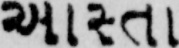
આસ્તા
